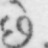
છે.
